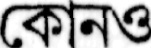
কোনও
